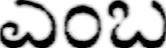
ಎಂಬ
